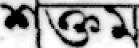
শক্তম
